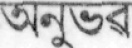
অনুভৱ
